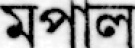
মপাল
